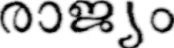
രാജ്യം
